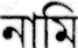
নামি
